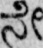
ನೇ
